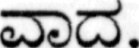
ವಾದ.
